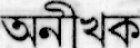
অনীখক
